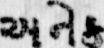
અનેક
